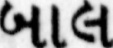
બાલ
